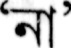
‘না’
